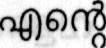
എന്റെ
